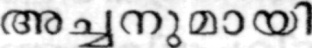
അച്ചനുമായി
